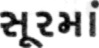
સૂરમાં
